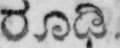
ರೂಢಿ.
